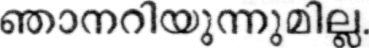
ഞാനറിയുന്നുമില്ല.
